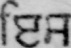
ਇਸ
